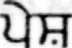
ਪੇਸ਼
